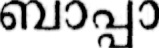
ബാപ്പാ
